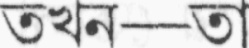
তখন—তা
